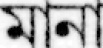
মানা
